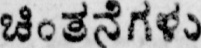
ಚಿಂತನೆಗಳು
